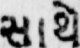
સાથે
